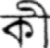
কী
